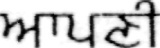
ਆਪਣੀ
